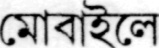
মোবাইলে
